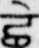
ਛੇ
